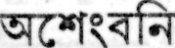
অশেংবনি
